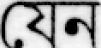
যেন
